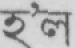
হ'ল
